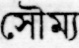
সৌম্য
